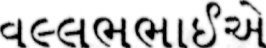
વલ્લભભાઈએ
